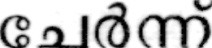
ചേര്‍ന്ന്
